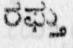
ರಫ್ತು
